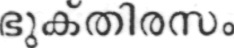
ഭുക്തിരസം
